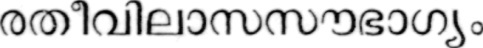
രതീവിലാസസൌഭാഗ്യം
